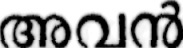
അവന്‍
